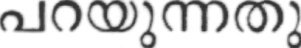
പറയുന്നതു
